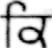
ਕਿ
